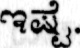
ಇಷ್ಟೆ.
